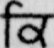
ਕਿ
